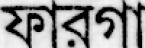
ফারগা
